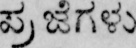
ಪ್ರಜೆಗಳು
